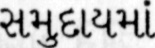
સમુદાયમાં
